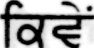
ਕਿਵੇਂ
